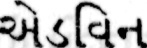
એડવિન
